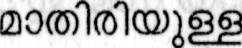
മാതിരിയുള്ള
